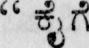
“ಕೈಗೆ
